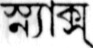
স্ন্যাক্স্
